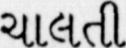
ચાલતી
